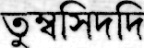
তুম্বসিদদি
